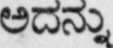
ಅದನ್ನು
